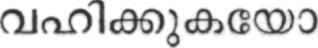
വഹിക്കുകയോ
